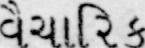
વૈચારિક
